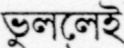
ভুললেই
